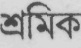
শ্ৰমিক
